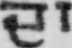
ਦਾ
